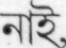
নাই,
